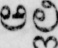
ಅಲ್ಲಿ
